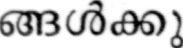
ങ്ങള്‍ക്കു
